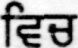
ਵਿਚ
